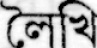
লৈখি
